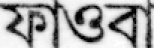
ফাওবা
